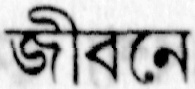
জীবনে
